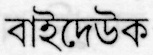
বাইদেউক
